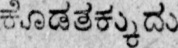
ಕೊಡತಕ್ಕುದು
